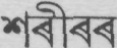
শৰীৰৰ
